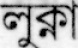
লুক্না
